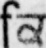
ਕਿ
